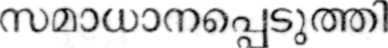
സമാധാനപ്പെടുത്തി
